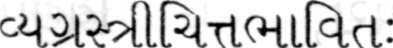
વ્યગ્રસ્ત્રીચિત્તભાવિતઃ
